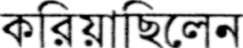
করিয়াছিলেন
